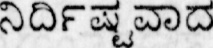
ನಿರ್ದಿಷ್ಟವಾದ
